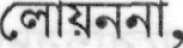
লোয়ননা,
